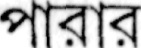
পারার
